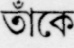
তাঁকে
